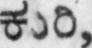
ಕುರಿ,
